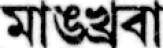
মাঙখ্রবা
